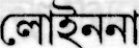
লোয়ননা
